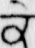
ਕੇ
